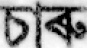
চাৰু
